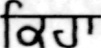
ਕਿਹਾ
